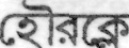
হৌরক্লে
